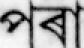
পৰা
